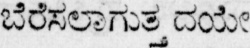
ಬೆರೆಸಲಾಗುತ್ತದಯೇ
